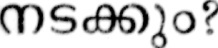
നടക്കും?
